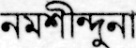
নমশীন্দুনা
